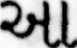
આ
